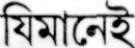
যিমানেই
